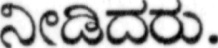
ನೀಡಿದರು.
